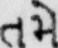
તમે
